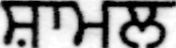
ਸ਼ਾਮਲ
